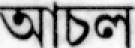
আচল
